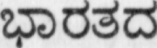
ಭಾರತದ
